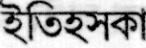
ইতিহাসকা
